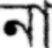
না
